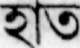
হাত
